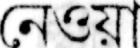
নেওয়া
